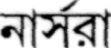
নার্সরা
